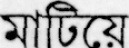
মাটিয়ে
